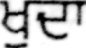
ਖੁਦਾ
